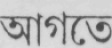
আগতে
